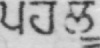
ਪਹਲੂ
